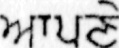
ਆਪਣੇ
